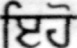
ਇਹੋ
